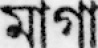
মাগা
